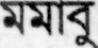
মমাবু
